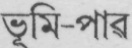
ভূমি-পাৱ
